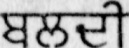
ਬਲਦੀ
